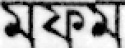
মফম
